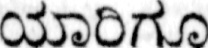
ಯಾರಿಗೂ
